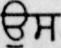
ਉਸ
